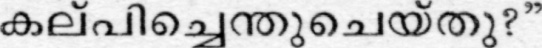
കല്പിച്ചെന്തുചെയ്തു?"
